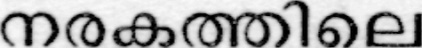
നരകത്തിലെ
